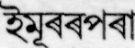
ইমূৰৰপৰা
